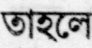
তাহলে
